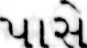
પાસે
